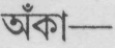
অঁকা-
